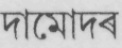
দামোদৰ
